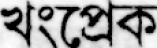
খংপ্রেক
